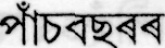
পাঁচবছৰৰ
